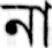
না
